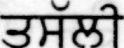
ਤਸੱਲੀ
